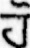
ਹੋ
